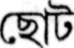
ছোট
